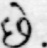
છે.
